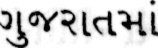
ગુજરાતમાં
